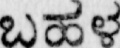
ಬಹಳ
